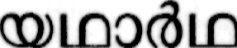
യഥാര്‍ഥ
